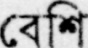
বেশি
